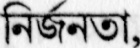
নির্জনতা,
